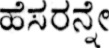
ಹೆಸರನ್ನೇ
